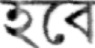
হবে
